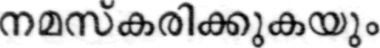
നമസ്കരിക്കുകയും
